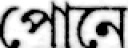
পোনে
